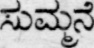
ಸುಮ್ಮನೆ
